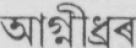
আগ্নীধ্রৰ
